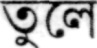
তুলে
